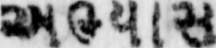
અભ્યાસ
